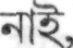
নাই,
